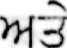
ਅਤੇ
